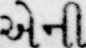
એની
